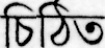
চিঠিত
